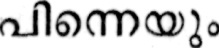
പിന്നെയും
